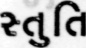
સ્તુતિ
